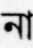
না
